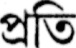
প্রতি
